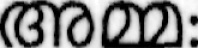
അമ്മ:
